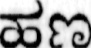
ಹಣ
